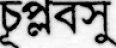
চূপ্লবসু
